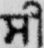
ਸੀ
